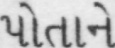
પોતાને
